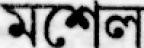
মশেল
